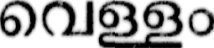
വെള്ളം
